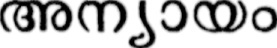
അന്യായം
